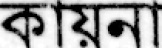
কায়না
